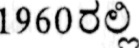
1960ರಲ್ಲಿ
